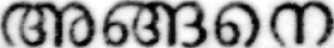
അങ്ങനെ
